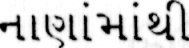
નાણાંમાંથી
